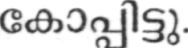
കോപ്പിട്ടു.
